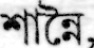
শান্নৈ,
